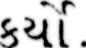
કર્યો.
